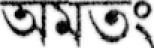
অমতং
